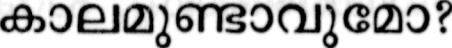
കാലമുണ്ടാവുമോ?
